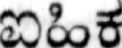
ಐಹಿಕ
